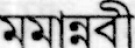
মমান্নবী
